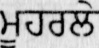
ਮੂਹਰਲੇ
